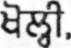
ਖੋਲ੍ਹੀ,
